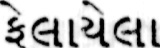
ફેલાયેલા
